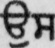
ਉਸ
